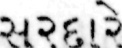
સરદારે
